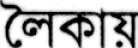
লৈকায়
